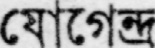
যোগেন্দ্র
